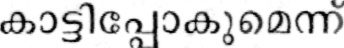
കാട്ടിപ്പോകുമെന്ന്
